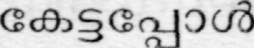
കേട്ടപ്പോള്‍
